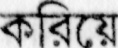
করিয়ে
